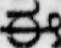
ಈ
